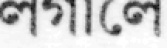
লগালে
